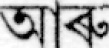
আৰু
